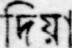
দিয়া
